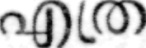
എത്ര
